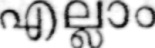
എല്ലാം
